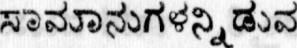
ಸಾಮಾನುಗಳನ್ನಿಡುವ
